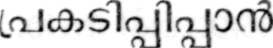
പ്രകടിപ്പിപ്പാന്‍
